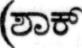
(ಶಾಕ್
